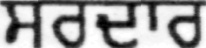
ਸਰਦਾਰ
